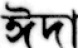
ঈদা
